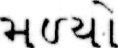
મળ્યો
